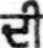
ਦੀ
